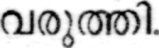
വരുത്തി.
